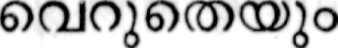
വെറുതെയും
